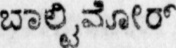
ಬಾಲ್ಟಿಮೋರ್
